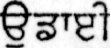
ਉਡਾਈ
